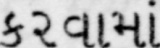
કરવામાં
